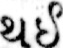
થઈ
